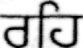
ਰਹਿ
